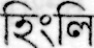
হিংলি
